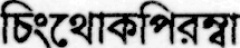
চিংথোকপিরম্বা
